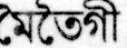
মৈতৈগী
